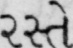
રસ્તે
